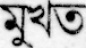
মুখত
